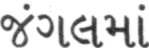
જંગલમાં
